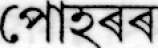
পোহৰৰ
